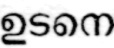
ഉടനെ
